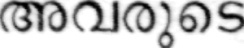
അവരുടെ
